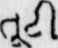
તૂટી
